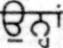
ਉਨ੍ਹਾਂ
